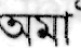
অমা
